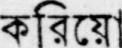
করিয়ো
